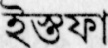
ইস্তফা
